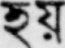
হয়
